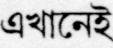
এখানেই
